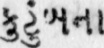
કુટુંબના
